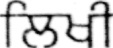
ਲਿਖੀ
